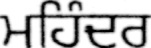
ਮਹਿੰਦਰ
